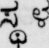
ಸ್ಥಳ
